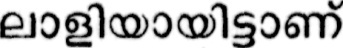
ലാളിയായിട്ടാണ്
